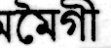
মমৈগী
